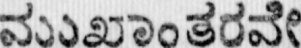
ಮುಖಾಂತರವೇ
